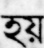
হয়
